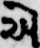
એ
